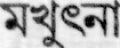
মখুৎনা
